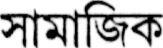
সামাজিক
